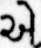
એ
